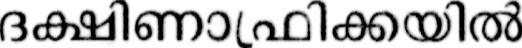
ദക്ഷിണാഫ്രിക്കയില്‍
